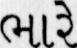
ભારે
